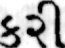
કરી
